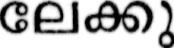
ലേക്കു
